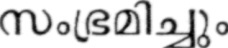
സംഭ്രമിച്ചും
